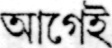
আগেই
